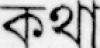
কথা
